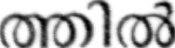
ത്തില്‍
